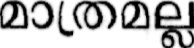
മാത്രമല്ല
